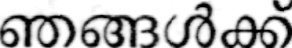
ഞങ്ങള്‍ക്ക്
